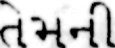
તેમની
